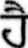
ਹੈ
